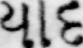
યાદ
